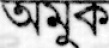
অমুক
